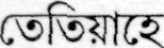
তেতিয়াহে
